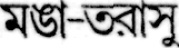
মঙা-তরাসু
